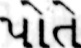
પોતે
